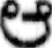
ಆ
